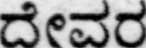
ದೇವರ
